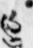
હું
